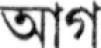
আগ
